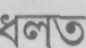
ধলত
